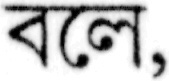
বলে,
